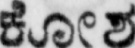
ಕೋಶ
